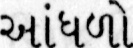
આંધળો
